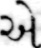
એ
